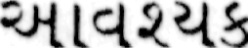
આવશ્યક
